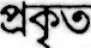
প্রকৃত
